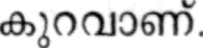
കുറവാണ്.
